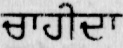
ਚਾਹੀਦਾ
